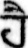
ਹੈ
